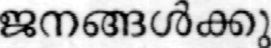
ജനങ്ങള്‍ക്കു
